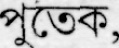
পুতেক,
